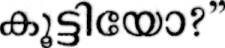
കൂട്ടിയോ?”
